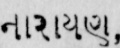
નારાયણ,
